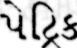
પેટ્રિક
